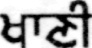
ਖਾਣੀ
